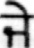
ਜੇ
